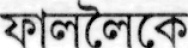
ফাললৈকে
